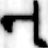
ન
